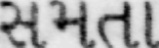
સમતા
